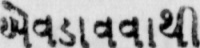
બેવડાવવાથી
